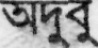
অদুবু
